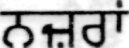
ਨਜ਼ਰਾਂ
